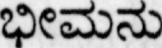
ಭೀಮನು
